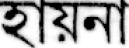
হায়না
